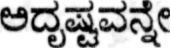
ಅದೃಷ್ಟವನ್ನೇ
